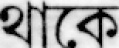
থাকে
